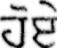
ਹੋਏ
